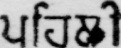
ਪਹਿਲੀ
